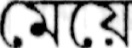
মেয়ে
